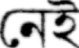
নেই
